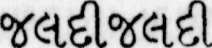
જલદીજલદી
